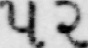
પર
